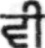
ਵੀ
